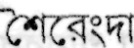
শৈরেংদা
